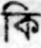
কি
